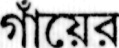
গাঁয়ের
